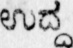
ಉದ್ದ
